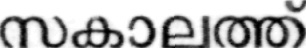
സകാലത്ത്
